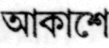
আকাশে
